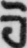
ਹੋ
